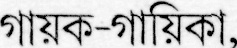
গায়ক-গায়িকা,
